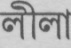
লীলা
